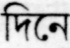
দিনে
